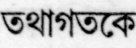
তথাগতকে
